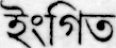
ইংগিত
